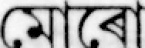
মোৰো
